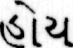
હોય
